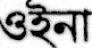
ওইনা
